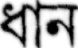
ধান
